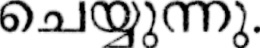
ചെയ്യുന്നു.
